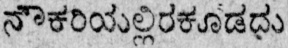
ನೌಕರಿಯಲ್ಲಿರಕೂಡದು
